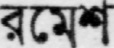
রমেশ
